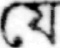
যে
